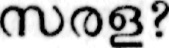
സരള?
